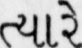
ત્યારે
